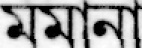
মমানা
